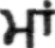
ਮਾਂ
